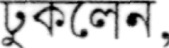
ঢুকলেন,
